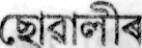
ছোৱালীৰ
